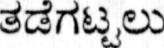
ತಡೆಗಟ್ಟಲು
